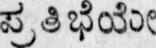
ಪ್ರತಿಭೆಯೇ
